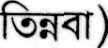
তিন্নবা)
